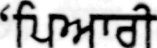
'ਪਿਆਰੀ
